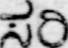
ಸರಿ
